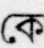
কে
